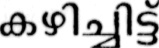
കഴിച്ചിട്ട്
